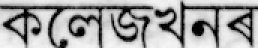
কলেজখনৰ
